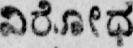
ವಿರೋಧ
